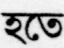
হতে
